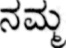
ನಮ್ಮ
